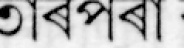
তাৰপৰা
